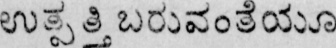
ಉತ್ಪತ್ತಿಬರುವಂತೆಯೂ
